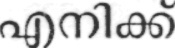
എനിക്ക്
